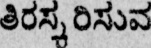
ತಿರಸ್ಕರಿಸುವ
